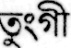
তুংগী
